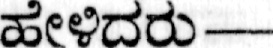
ಹೇಳಿದರು-
